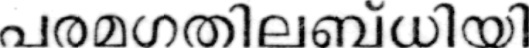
പരമഗതിലബ്ധിയി
